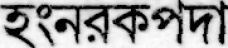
হংনরকপদা
